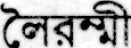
লৈরম্মী
